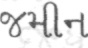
જમીન
